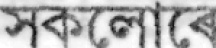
সকলোৰে
